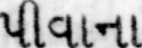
પીવાના
